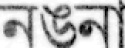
নঙনা
